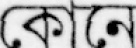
কোনে
